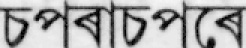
চপৰাচপৰে
